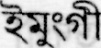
ইমুংগী
